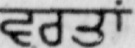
ਵਰਤਾਂ
